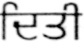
ਦਿਤੀ
